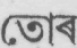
তোৰ
